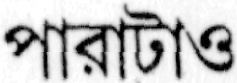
পারাটাও
